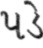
પડે
